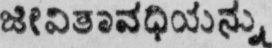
ಜೀವಿತಾವಧಿಯನ್ನು
